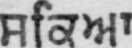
ਸਕਿਆ
